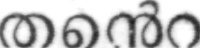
തന്റെ
